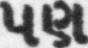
પણ
